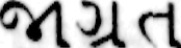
જાગ્રત
